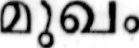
മുഖം
